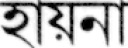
হায়না
